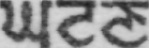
ਘਟਣ
